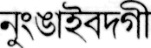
নুংঙাইবদগী
